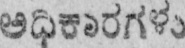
ಅಧಿಕಾರಗಳು
